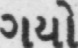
ગયો
